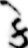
કે
